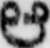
ಆ
